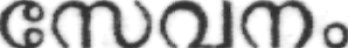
സേവനം
